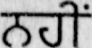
ਨਹੀਂ
